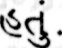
હતું.
